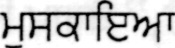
ਮੁਸਕਾਇਆ
